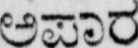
ಅಪಾರ
